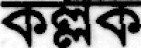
কল্লক
